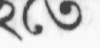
হতে
